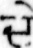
ਦੇ
